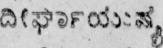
ದೀರ್ಘಾಯುಷ್ಯ
